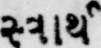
સ્વાર્થ
